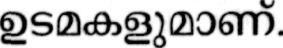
ഉടമകളുമാണ്.
